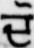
ਦੋ
